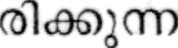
രിക്കുന്ന
